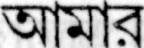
আমার
